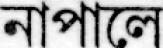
নাপালে
